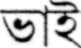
ভাই
